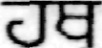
ਹਥ
